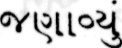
જણાવ્યું
